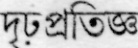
দৃঢ়প্রতিজ্ঞ
